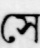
সে
